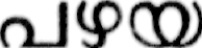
പഴയ
